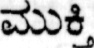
ಮುಕ್ತಿ
